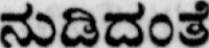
ನುಡಿದಂತೆ
